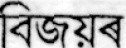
বিজয়ৰ
